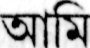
আমি
